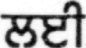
ਲਈ
